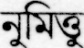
নুমিত্তু
